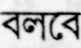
বলবে
